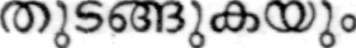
തുടങ്ങുകയും
